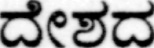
ದೇಶದ
